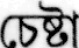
চেষ্টা
